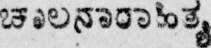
ಚಾಲನಾರಾಹಿತ್ಯ
